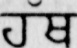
ਹੱਥ
